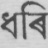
ধৰি
